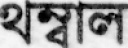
থম্বাল
